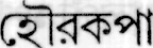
হৌরকপা
